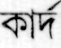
কার্দ
